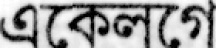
একেলগে
